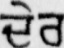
ਦੇਰ
